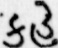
કહે
